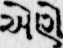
એણે
